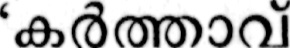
'കര്‍ത്താവ്
